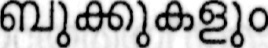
ബുക്കുകളും
